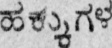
ಹಕ್ಕುಗಳ
